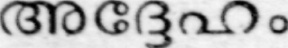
അദ്ദേഹം
